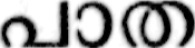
പാത
